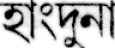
হাংদুনা
